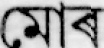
মোৰ
